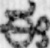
ಈ
